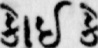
કોઈકે
